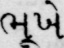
ભૂખે
